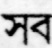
সব
